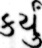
કર્યું
